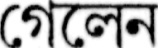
গেলেন
